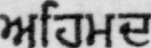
ਅਹਿਮਦ
